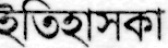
ইতিহাসকা
